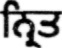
ਨ੍ਰਿਤ
